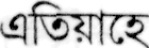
এতিয়াহে
